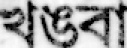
খঙবা
